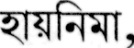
হায়নিমা,
